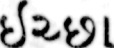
ઇચ્છા
